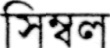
সিম্বল
